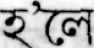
হ'লে
